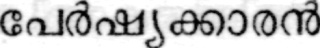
പേര്‍ഷ്യക്കാരന്‍
